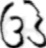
ઉડે
